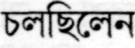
চলছিলেন
